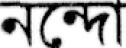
নন্দো
